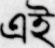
এই
